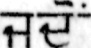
ਜਦੋਂ
